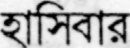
হাসিবার
